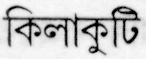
কিলাকুটি
